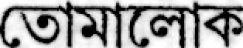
তোমালোক
